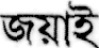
জয়াই
